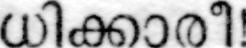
ധിക്കാരീ!
